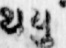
થયું
